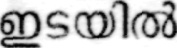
ഇടയില്‍
